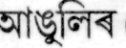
আঙুলিৰ
